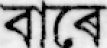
বাৰে
